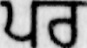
ਪਰ
